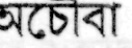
অচৌবা
